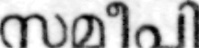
സമീപി
